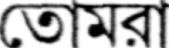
তোমরা
